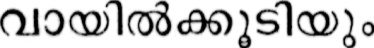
വായില്‍ക്കൂടിയും
